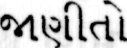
જાણીતો
